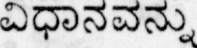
ವಿಧಾನವನ್ನು
